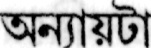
অন্যায়টা
